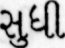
સુધી
